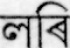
লৰি
